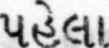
પહેલા
